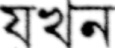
যখন
